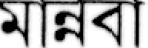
মান্নবা
